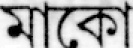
মাকো
